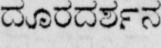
ದೂರದರ್ಶನ
